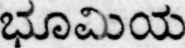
ಭೂಮಿಯ
